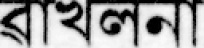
ৱাখলনা
